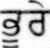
ਭੂਰੇ
